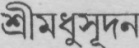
শ্ৰীমধুসূদন
